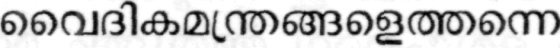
വൈദികമന്ത്രങ്ങളെത്തന്നെ
